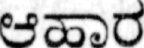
ಆಹಾರ
